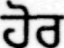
ਹੋਰ
